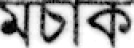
মচাক
